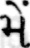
મેં
